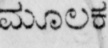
ಮೂಲಕ
